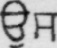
ਉਸ
